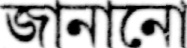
জানানো
